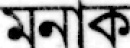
মনাক
